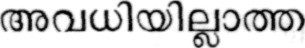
അവധിയില്ലാത്ത
